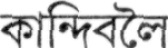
কান্দিবলৈ
